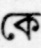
কে
